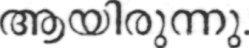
ആയിരുന്നു.
